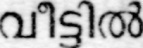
വീട്ടില്‍
